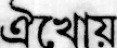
ঐখোয়
